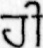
ਹੀ
